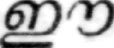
ഈ
